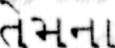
તેમના
